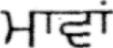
ਮਾਵਾਂ
